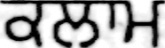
ਕਲਾਮ
